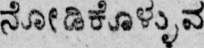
ನೋಡಿಕೊಳ್ಳುವ
